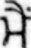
ਮੈਂ
